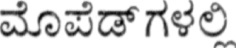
ಮೊವೆಡ್ ಗಳಲ್ಲಿ
